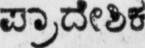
ಪ್ರಾದೇಶಿಕ
